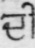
ਦੀ
